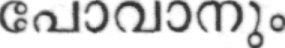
പോവാനും
